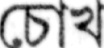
চোখ
